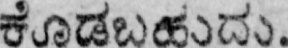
ಕೊಡಬಹುದು.
